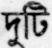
দুটি
